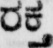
ರಕ್ತ
